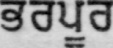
ਭਰਪੂਰ
